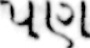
પણ
